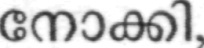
നോക്കി,
